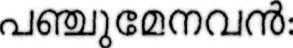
പഞ്ചുമേനവന്‍:
